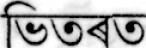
ভিতৰত
